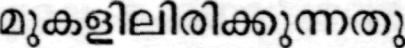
മുകളിലിരിക്കുന്നതു
